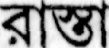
রাস্তা
